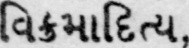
વિક્રમાદિત્ય,
